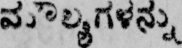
ಮೌಲ್ಯಗಳನ್ನು
